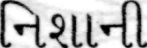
નિશાની
